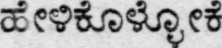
ಹೇಳಿಕೊಳ್ಳೋಕೆ
